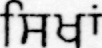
ਸਿਖਾਂ
